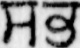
ਸਭ
